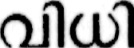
വിധി
